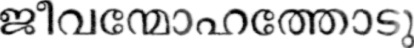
ജീവന്മോഹത്തോടു
